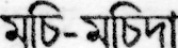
মচি-মচিদা
